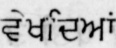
ਵੇਖਦਿਆਂ
